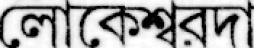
লোকেশ্বরদা
